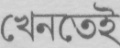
খেনতেই
